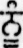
ਨੂੰ
